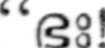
"ഭഃ!
